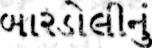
બારડોલીનું
